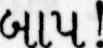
બાપ!
